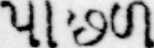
પાછળ
